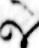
જે
